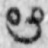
ಆ
